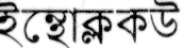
ইন্থোক্লকউ
